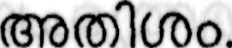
അതിശം.
